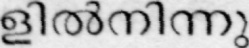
ളില്‍നിന്നു
